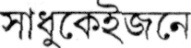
সাধুকেইজনে
